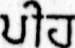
ਪੀਹ
